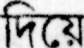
দিয়ে
